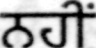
ਨਹੀਂ
